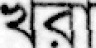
খরা
